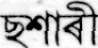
ছশাৰী
